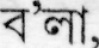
ব'লা,
